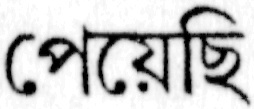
পেয়েছি
